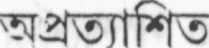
অপ্রত্যাশিত
